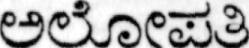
ಅಲೋಪತಿ
